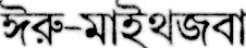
ঈরু-মাইথজবা
